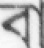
বা
